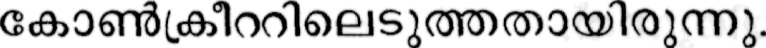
കോണ്‍ക്രീററിലെടുത്തതായിരുന്നു.
